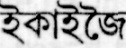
ইকাইজে
